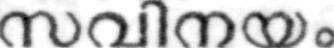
സവിനയം
